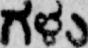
ಗಳು
